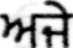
ਅਜੇ
